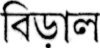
বিড়াল
